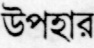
উপহার
